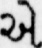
એ
